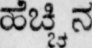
ಹೆಚ್ಚಿನ
